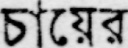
চায়ের
